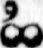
ಹಿ
